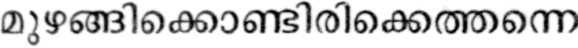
മുഴങ്ങിക്കൊണ്ടിരിക്കെത്തന്നെ
